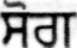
ਸੋਗ
